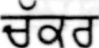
ਚੱਕਰ
